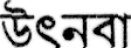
উৎনবা
